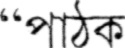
“পাঠক
